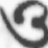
ও
